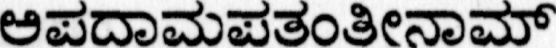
ಅಪದಾಮಪತಂತೀನಾಮ್
